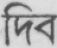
দিব
